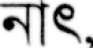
নাৎ,
